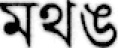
মথঙ
